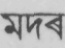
মদৰ
